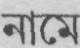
নামে
